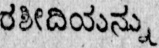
ರಶೀದಿಯನ್ನು
